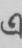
এ
